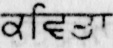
ਕਵਿਤਾ
